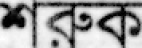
শরূক
